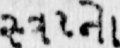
સ્વપ્નો
